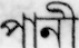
পানী
